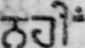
ਨਹੀਂ
